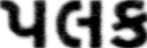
પલક
